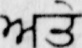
ਅਤੇ
